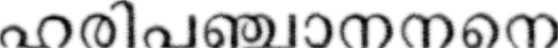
ഹരിപഞ്ചാനനനെ
